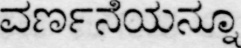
ವರ್ಣನೆಯನ್ನೂ
